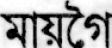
মায়গৈ
